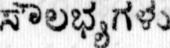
ಸೌಲಭ್ಯಗಳು
